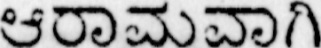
ಆರಾಮವಾಗಿ
